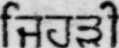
ਜਿਹੜੀ
